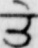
ਤੇ
